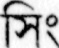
সিং
